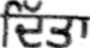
ਦਿੱਤਾ
